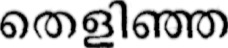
തെളിഞ്ഞ
